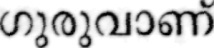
ഗുരുവാണ്
